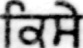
ਕਿਸੇ
